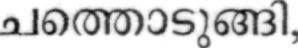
ചത്തൊടുങ്ങി,
